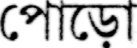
পোড়ো
